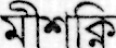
মীশক্নি
